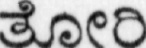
ತೋರಿ
